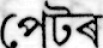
পেটৰ
